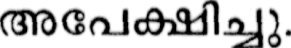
അപേക്ഷിച്ചു.
